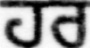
ਹਰ
